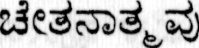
ಚೇತನಾತ್ಮವು
